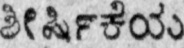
ಶೀರ್ಷಿಕೆಯ
